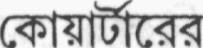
কোয়ার্টারের
